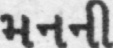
મનની
